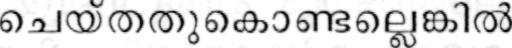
ചെയ്തതുകൊണ്ടല്ലെങ്കില്‍
